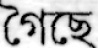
গৈছে
